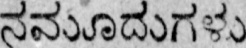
ನಮೂದುಗಳು
